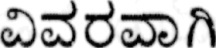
ವಿವರವಾಗಿ
